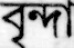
বৃন্দা
